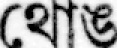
থোঙ
